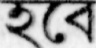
হবে
